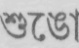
শুঙো
